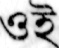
ওই
